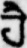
ਹੈ
